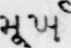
મૂર્ખ
